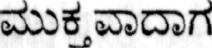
ಮುಕ್ತವಾದಾಗ
